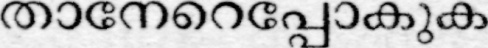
താനേറെപ്പോകുക
